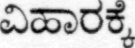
ವಿಹಾರಕ್ಕೆ
